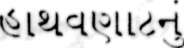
હાથવણાટનું
